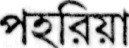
পহরিয়া
